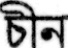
চীন
